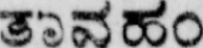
ತಾವಹಂ
